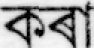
কৰা
